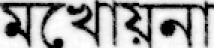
মখোয়না
